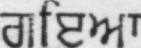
ਗਇਆ
